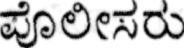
ಪೊಲೀಸರು
